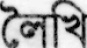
লৈখি
